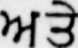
ਅਤੇ
